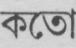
কতো
